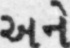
અને
